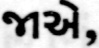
જાએ,
